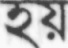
হয়
